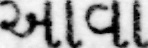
આવા
